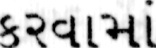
કરવામાં
